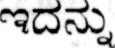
ಇದನ್ನು
